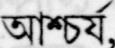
আশ্চর্য,
